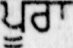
ਪੂਰਾ
